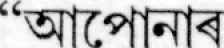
"আপোনাৰ
